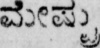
ಮೇಷ್ಟ್ರು
